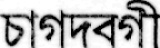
চাগদবগী
